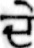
ਦੇ
